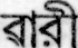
ৱারী
